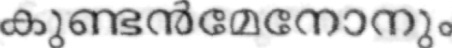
കുണ്ടന്‍മേനോനും
